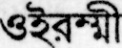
ওইরম্মী
